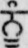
ਨੂੰ
